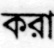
করা
